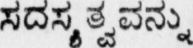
ಸದಸ್ಯತ್ವವನ್ನು
